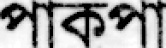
পাকপা
